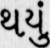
થયું
